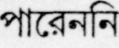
পারেননি
